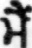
ਮੈਂ
